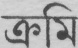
ক্ৰমি
